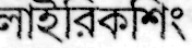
লাইরিকশিং
